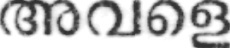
അവളെ
